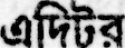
এদিটর
